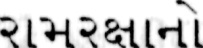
રામરક્ષાનો
